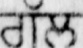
ਗੱਲ
